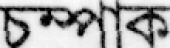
চম্পাক
